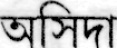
অসিদা
